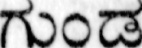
ಗುಂಡ
